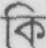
কি
